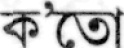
ক'তো
